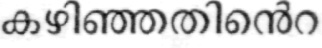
കഴിഞ്ഞതിന്റെ
